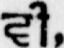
ਵੀ,
